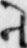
ને
